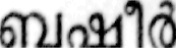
ബഷീര്‍
